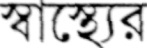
স্বাস্থ্যের
